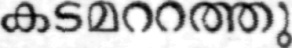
കടമററത്തു
